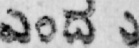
ಎಂದು
